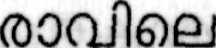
രാവിലെ
